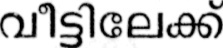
വീട്ടിലേക്ക്
